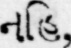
નહિ,
